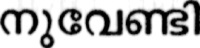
നുവേണ്ടി
